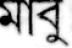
মাবু
